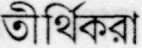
তীর্থিকরা
